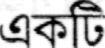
একটি
